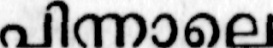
പിന്നാലെ
